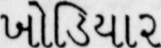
ખોડિયાર
